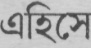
এহিসে
